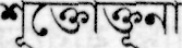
শূক্তোক্তুনা
